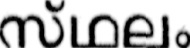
സ്ഥലം
